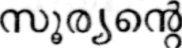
സൂര്യന്റെ
